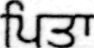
ਪਿਤਾ
